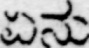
ಏನು
